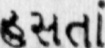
હસતાં
